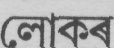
লোকৰ
